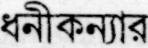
ধনীকন্যার
